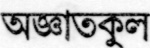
অজ্ঞাতকুল
